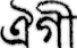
ঐগী
